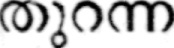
തുറന്ന
